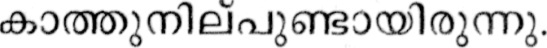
കാത്തുനില്പുണ്ടായിരുന്നു.
